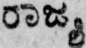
ರಾಜ್ಯ
